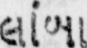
લાંબા
